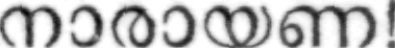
നാരായണ!
